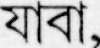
যাবা,
